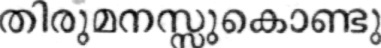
തിരുമനസ്സുകൊണ്ടു
